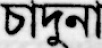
চাদুনা
